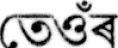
তেওঁৰ
